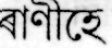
ৰাণীহে
